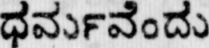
ಧರ್ಮವೆಂದು
